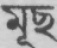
মূছ
